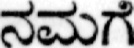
ನಮಗೆ
